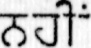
ਨਹੀਂ
